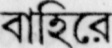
বাহিরে
